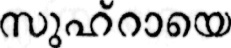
സുഹ്റായെ
